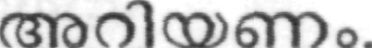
അറിയണം.
